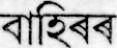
বাহিৰৰ
